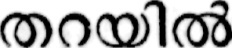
തറയില്‍
